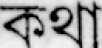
কথা
